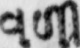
વળી
